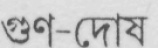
গুণ-দোষ
